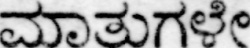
ಮಾತುಗಳೇ
